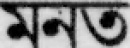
মনত
